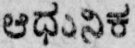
ಆಧುನಿಕ
